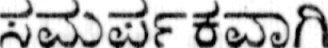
ಸಮರ್ಪಕವಾಗಿ
